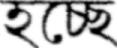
হচ্ছে
